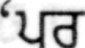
'ਪਰ
